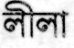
লীলা
